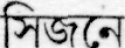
সিজনে
